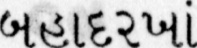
બહાદરખાં
